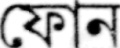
ফোন
